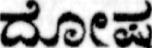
ದೋಷ
